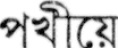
পখীয়ে
